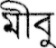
মীবু
